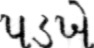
પડખે
